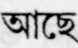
আছে
